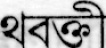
থবক্তী
